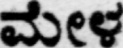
ಮೇಳ
